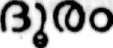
ദൂരം
